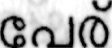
പേര്
